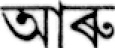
আৰু
